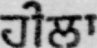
ਹੀਲਾ
